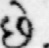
છે.
